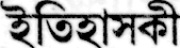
ইতিহাসকী
